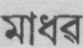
মাধৱ
